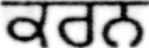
ਕਰਨ
